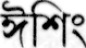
ঈশিং
